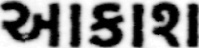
આકાશ
